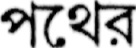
পথের
